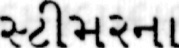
સ્ટીમરના
